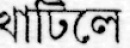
খাটিলে
